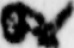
જ
